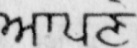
ਆਪਣੇ
